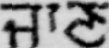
ਜਾਣ
